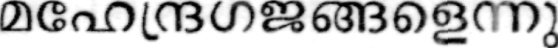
മഹേന്ദ്രഗജങ്ങളെന്നു
